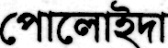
পোলোইদা
